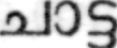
ചാട്ട
